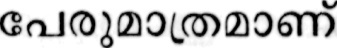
പേരുമാത്രമാണ്
